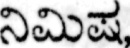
ನಿಮಿಷ,
